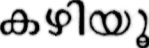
കഴിയൂ
